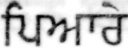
ਪਿਆਰੇ
